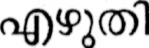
എഴുതി
